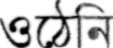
ওঠেনি
